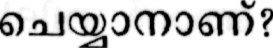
ചെയ്യാനാണ്?
